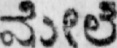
ಮೇಲೆ
